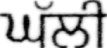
ਘੱਲੀ
